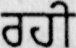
ਰਹੀ
